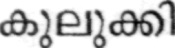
കുലുക്കി
